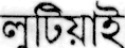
লুটিয়াই
